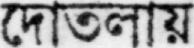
দোতলায়
